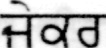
ਜੇਕਰ
